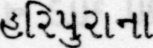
હરિપુરાના
